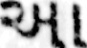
આ
